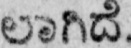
ಲಾಗಿದೆ.
